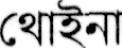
থোইনা
